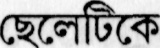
ছেলেটিকে
